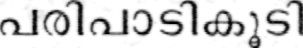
പരിപാടികൂടി
